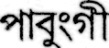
পাবুংগী
